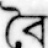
বৈ
